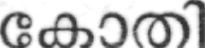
കോതി
